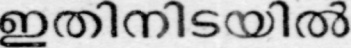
ഇതിനിടയില്‍
